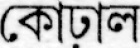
কোঢ়াল
